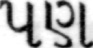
પણ
